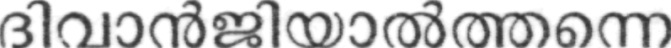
ദിവാന്‍ജിയാല്‍ത്തന്നെ
